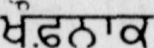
ਖੌਫ਼ਨਾਕ
